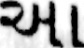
આ
